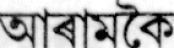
আৰামকৈ
